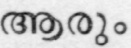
ആരും
